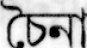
চৈনা
